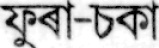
ফুৰা-চকা
